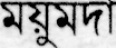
ময়ুমদা
